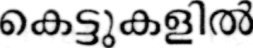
കെട്ടുകളില്‍
